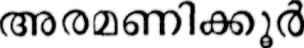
അരമണിക്കൂര്‍
